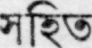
সহিত
